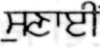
ਸੁਣਾਈਂ
